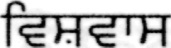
ਵਿਸ਼ਵਾਸ਼
